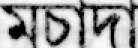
মচাদা
